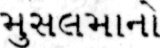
મુસલમાનો
